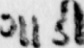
ગાડી
